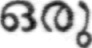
ഒരു
